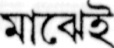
মাঝেই
